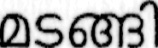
മടങ്ങി
